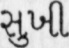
સુખી
